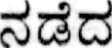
ನಡೆದ
